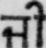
ਜੀ
